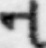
ન
